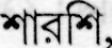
শারশি,
